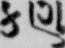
કણ
